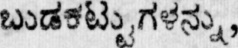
ಬುಡಕಟ್ಟುಗಳನ್ನು,
